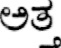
ಅತ್ತ
